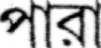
পারা
